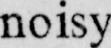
noisy
